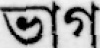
ভাগ
